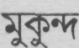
মুকুন্দ
